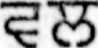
ਵਲ
